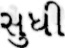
સુધી
